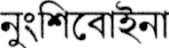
নুংশিবোইনা
